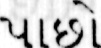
પાછો
